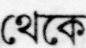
থেকে
